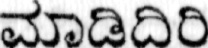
ಮಾಡಿದಿರಿ
